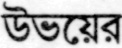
উভয়ের
